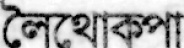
লৈথোকপা
